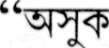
“অসুক
